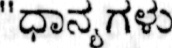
“ಧಾನ್ಯಗಳು
